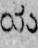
ಯ
